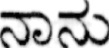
ನಾನು
